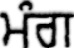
ਮੰਗ
